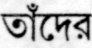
তাঁদের
